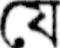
যে
